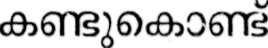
കണ്ടുകൊണ്ട്
